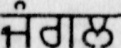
ਜੰਗਲ
